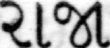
રાજા
